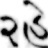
રહે
